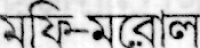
মফি-মরোল
